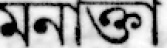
মনাক্তা
